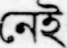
নেই
